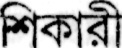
শিকারী
